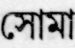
সোমা
